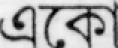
একো
